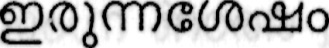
ഇരുന്നശേഷം
